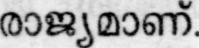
രാജ്യമാണ്.
